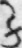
કે
